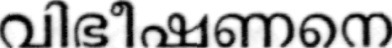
വിഭീഷണനെ
